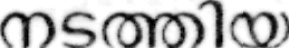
നടത്തിയ
